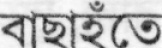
বাছাহঁতে
